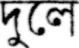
দুলে
